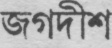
জগদীশ
